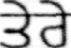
ਤੇਰੇ
